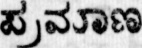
ಪ್ರಮಾಣ
